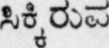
ಸಿಕ್ಕಿರುವ
